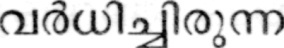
വര്‍ധിച്ചിരുന്ന
